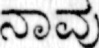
ನಾವು
